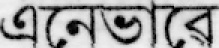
এনেভাৱে
